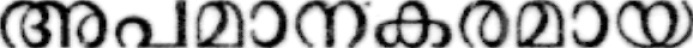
അപമാനകരമായ
